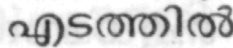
എടത്തില്‍
